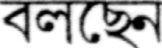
বলছেন
